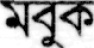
মবুক
